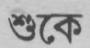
শুকে
